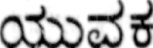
ಯುವಕ
